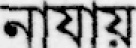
নাযায়
